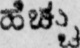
ಹೆಚ್ಚು
